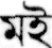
মই
